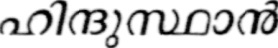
ഹിന്ദുസ്ഥാന്‍
